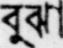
বুঝা
